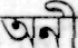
অনী
